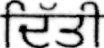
ਦਿੱਤੀ
